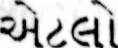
એટલો
